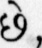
છે,
